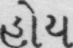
હોય
